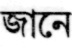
জানে
